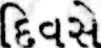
દિવસે
